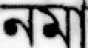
নমা
